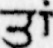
ਤਾਂ
